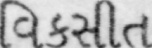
વિકસીત
